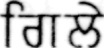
ਗਿਲੇ
